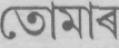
তোমাৰ
